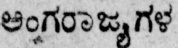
ಅಂಗರಾಜ್ಯಗಳ
